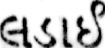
લડાઈ
